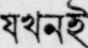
যখনই
